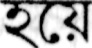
হয়ে
